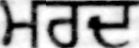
ਮਰਦ
